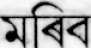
মৰিব
